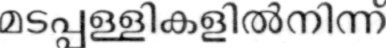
മടപ്പള്ളികളില്‍നിന്ന്
